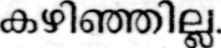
കഴിഞ്ഞില്ല.
